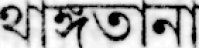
থাঙ্গতানা
